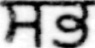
ਸਭ
